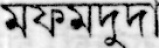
মফমদুদা
